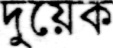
দুয়েক
